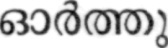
ഓര്‍ത്തു
